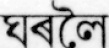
ঘৰলৈ
